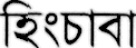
হিংচাবা
